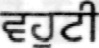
ਵਹੁਟੀ
